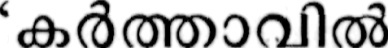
'കര്‍ത്താവില്‍
